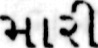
મારી
